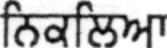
ਨਿਕਲਿਆ
